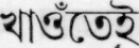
খাওঁতেই
